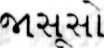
જાસૂસો
